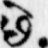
છે.
